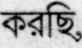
করছি,
